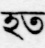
হত
